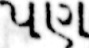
પણ
